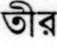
তীর
